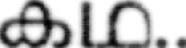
കഥ..
